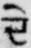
ਦੇ
